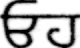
ਓਹ
